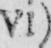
vi)
